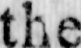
the
